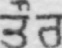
ਤੌਰ
